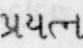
પ્રયત્ન
